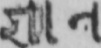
જ્ઞાન
